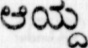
ಆಯ್ದ
